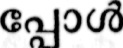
പ്പോള്‍
